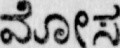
ಮೋಸ
